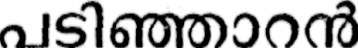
പടിഞ്ഞാറന്‍
